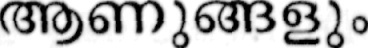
ആണുങ്ങളും
